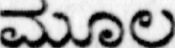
ಮೂಲ
